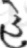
હે
